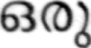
ഒരു
